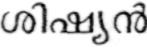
ശിഷ്യന്‍
